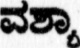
ವಶ್ಯಾ
